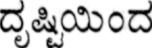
ದೃಷ್ಟಿಯಿಂದ
